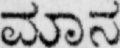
ಮಾನ
